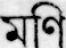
মণি
